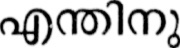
എന്തിനു
